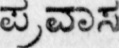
ಪ್ರವಾಸ
